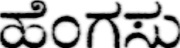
ಹೆಂಗಸು
